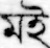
মই
